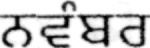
ਨਵੰਬਰ
